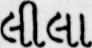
લીલા
